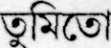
তুমিতো
